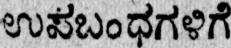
ಉಪಬಂಧಗಳಿಗೆ
